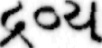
દ્રવ્ય
